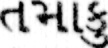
તમાકુ
